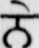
ਨੇ
